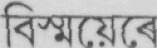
বিস্ময়েৰে
